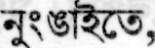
নুংঙাইতে,
